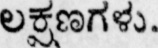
ಲಕ್ಷಣಗಳು.
